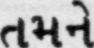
તમને
